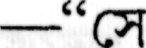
-"সে
